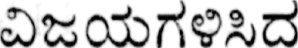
ವಿಜಯಗಳಿಸಿದ
